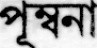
পূম্বনা
